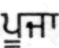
ਪੂਜਾ
